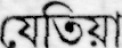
যেতিয়া
